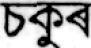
চকুৰ
